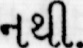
નથી.
